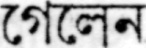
গেলেন
